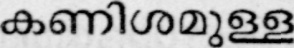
കണിശമുള്ള
